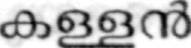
കള്ളന്‍
